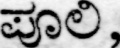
ಪೂಲಿ,
